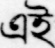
এই
